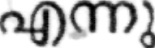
എന്നു
